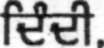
ਦਿੰਦੀ,
